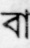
বা
